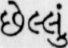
છેલ્લું
